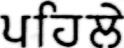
ਪਹਿਲੇ
